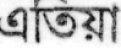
এতিয়া
